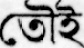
তৌই
